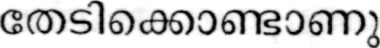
തേടിക്കൊണ്ടാണു
